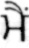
ਮੈਂ
